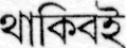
থাকিবই
